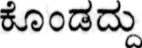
ಕೊಂಡದ್ದು
